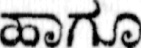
ಹಾಗೂ
